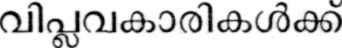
വിപ്ലവകാരികള്‍ക്ക്
